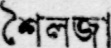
শৈলজা
